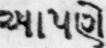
આપણે
